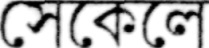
সেকেলে
